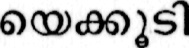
യെക്കൂടി
